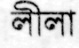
লীলা
